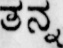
ತನ್ನ
